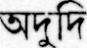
অদুদি
